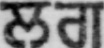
ਲਗ
